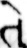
તે
